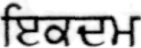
ਇਕਦਮ
